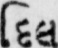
દિલ
